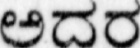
ಅದರ
